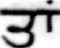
ਤਾਂ
